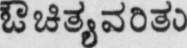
ಔಚಿತ್ಯವರಿತು
